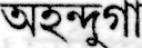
অহন্দুগা
